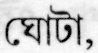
ঘোটা,
